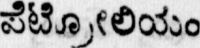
ಪೆಟ್ರೋಲಿಯಂ
